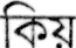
কিয়
